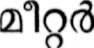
മീറ്റര്‍
